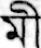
মী
